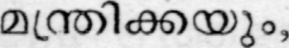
മന്ത്രിക്കയും,
